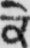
ਕੇ
